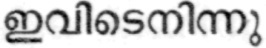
ഇവിടെനിന്നു
